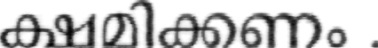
ക്ഷമിക്കണം.
